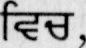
ਵਿਚ,
